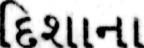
દિશાના
